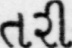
તરી
